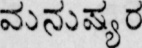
ಮನುಷ್ಯರ
